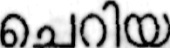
ചെറിയ
